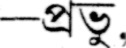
–প্রভু,
